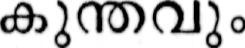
കുന്തവും
